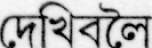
দেখিবলৈ
